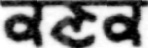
ਕਣਕ
